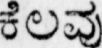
ಕೆಲವು
